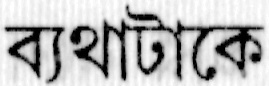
ব্যথাটাকে
